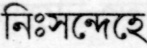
নিঃসন্দেহে
